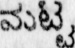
ಮಟ್ಟ
